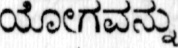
ಯೋಗವನ್ನು
